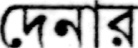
দেনার
